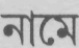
নামে
